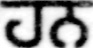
ਹਨ
